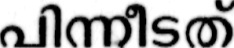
പിന്നീടത്
